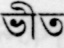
ভীত
